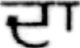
ਦਾ
